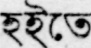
হইতে
